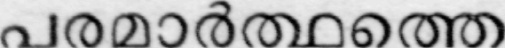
പരമാര്‍ത്ഥത്തെ
